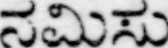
ನಮಿಸು
